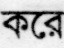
করে
